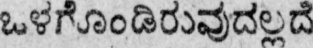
ಒಳಗೊಂಡಿರುವುದಲ್ಲದೆ
